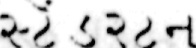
સ્ટૅડરટન
